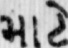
માટે
